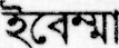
ইবেম্মা
